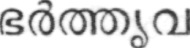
ഭര്‍ത്തൃവ
